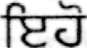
ਇਹੋ
